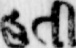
હતી
